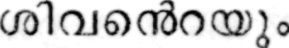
ശിവന്റെയും
